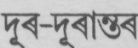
দূৰ-দূৰান্তৰ
